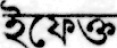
ইফেক্ত
